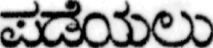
ಪಡೆಯಲು
